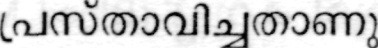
പ്രസ്താവിച്ചതാണു
